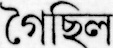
গৈছিল
